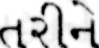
તરીને
